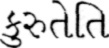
કુરુતેતિ
